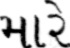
મારે
